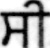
ਸੀ
